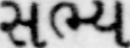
સભ્ય
